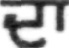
ਦਾ
